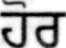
ਹੋਰ
